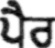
ਪੈਰ
